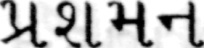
પ્રશમન
